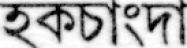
হকচাংদা
